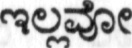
ಇಲ್ಲವೋ
